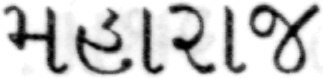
મહારાજ
